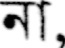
না,
